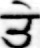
ਤੇ
